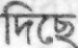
দিছে
